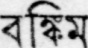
বঙ্কিম
